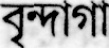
বৃন্দাগা
